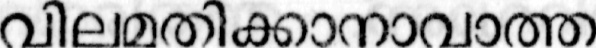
വിലമതിക്കാനാവാത്ത
